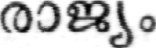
രാജ്യം
